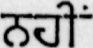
ਨਹੀਂ
